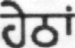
ਹੇਠਾਂ
